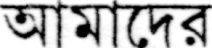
আমাদের
